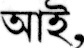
আই,
